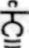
ਨੂੰ
